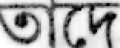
তাদে
